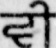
ਵੀ
